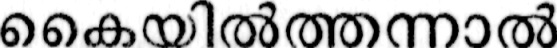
കൈയില്‍ത്തന്നാല്‍
